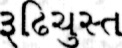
રૂઢિચુસ્ત
